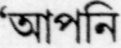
‘আপনি
